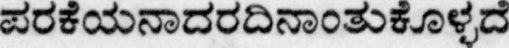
ಪರಕೆಯನಾದರದಿನಾಂತುಕೊಳ್ಳದೆ
